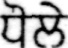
ਧੌਲੇ
